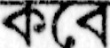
কবে
